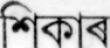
শিকাৰ
